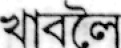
খাবলৈ
